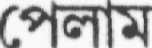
পেলাম
